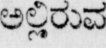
ಅಲ್ಲಿರುವ
